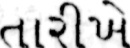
તારીખે
